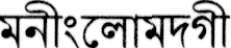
মনীংলোমদগী
